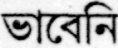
ভাবেনি
